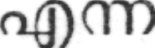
എന്ന
